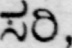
ಸರಿ,
